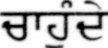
ਚਾਹੁੰਦੇ
